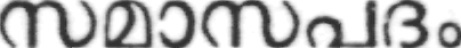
സമാസപദം
